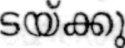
ടയ്ക്കു
